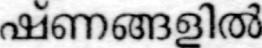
ഷ്ണങ്ങളില്‍
